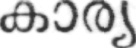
കാര്യ
